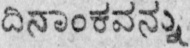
ದಿನಾಂಕವನ್ನು
